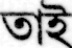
তাই
